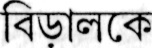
বিড়ালকে
